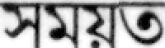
সময়ত
